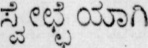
ಸ್ವೇಛ್ಛೆಯಾಗಿ
